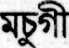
মচুগী
